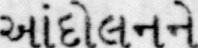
આંદોલનને
